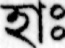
হাঃ
